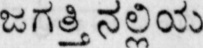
ಜಗತ್ತಿನಲ್ಲಿಯ
